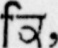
ਕਿ,
